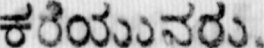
ಕರೆಯುವರು.
